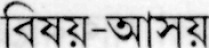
বিষয়-আসয়
